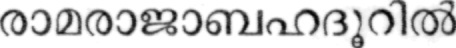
രാമരാജാബഹദൂറില്‍
